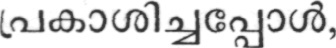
പ്രകാശിച്ചപ്പോള്‍,
